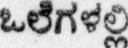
ಒಲೆಗಳಲ್ಲಿ
